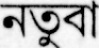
নতুবা
